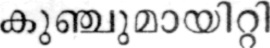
കുഞ്ചുമായിറ്റി
